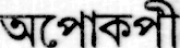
অপোকপী
